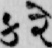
કરે
